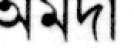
অমদা
